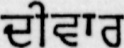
ਦੀਵਾਰ
